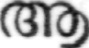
ആ
